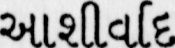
આશીર્વાદ
